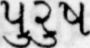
પુરુષ
